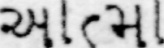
આત્મા
